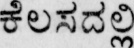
ಕೆಲಸದಲ್ಲಿ
